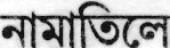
নামাতিলে
